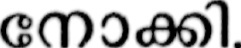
നോക്കി.
